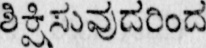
ಶಿಕ್ಷಿಸುವುದರಿಂದ
